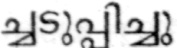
ച്ചടുപ്പിച്ചു
